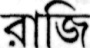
রাজি
